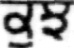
ਕੁਝ
